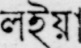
লইয়া
